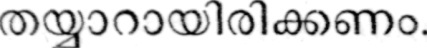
തയ്യാറായിരിക്കണം.
